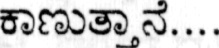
ಕಾಣುತ್ತಾನೆ.....
